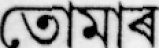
তোমাৰ
